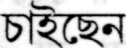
চাইছেন
